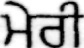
ਮੇਰੀ
